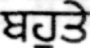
ਬਹੁਤ
